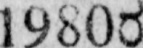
1980ರ
